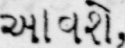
આવશે,
